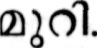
മുറി.
